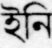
ইনি
